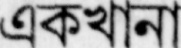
একখানা
